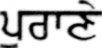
ਪੁਰਾਣੇ
